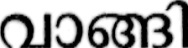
വാങ്ങി
